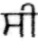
ਸੀ
